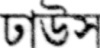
ঢাউস
